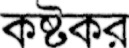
কষ্টকর
